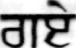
ਗਏ
